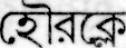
হৌরক্লে
